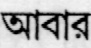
আবার
